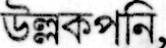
উল্লকপনি,
